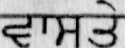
ਵਾਸਤੇ
